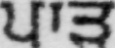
ਪਾੜ
